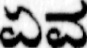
ಏವ
